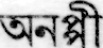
অনপ্পী
